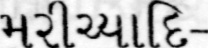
મરીચ્યાદિ-
